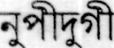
নুপীদুগী
